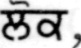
ਲੋਕ,
